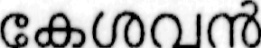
കേശവന്‍
